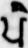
ਪੈ
